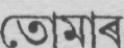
তোমাৰ
